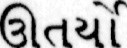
ઊતર્યો
